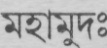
মহামুদঃ
